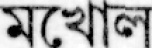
মখোল
